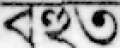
বহুত
